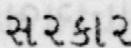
સરકાર
